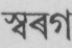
স্বৰগ
